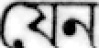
যেন
